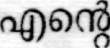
എന്റെ
